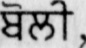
ਬੋਲੀ,
